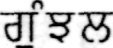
ਗੁੰਝਲ
